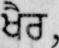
ਖੈਰ,
